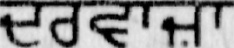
ਦਰਵਾਜ਼ਾ
